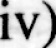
iv)
